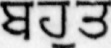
ਬਹੁਤ
